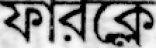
ফারক্লে
